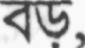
বড়,
